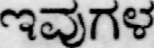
ಇವುಗಳ
